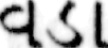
વડા
